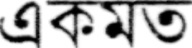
একমত
